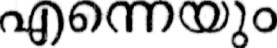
എന്നെയും
